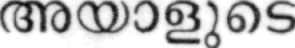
അയാളുടെ
